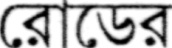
রোডের
